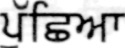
ਪੁੱਛਿਆ
